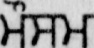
ਮੌਸਮ
